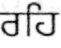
ਰਹਿ
